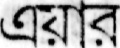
এয়ার
